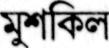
মুশকিল
